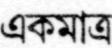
একমাত্র
